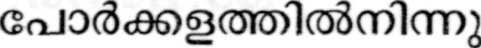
പോര്‍ക്കളത്തില്‍നിന്നു
